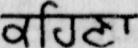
ਕਹਿਣਾ
